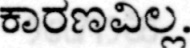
ಕಾರಣವಿಲ್ಲ.
